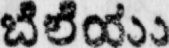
ಬೆಲೆಯು
